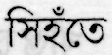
সিহঁতে
